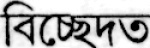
বিচ্ছেদত
